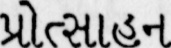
પ્રોત્સાહન
